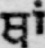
ਥਾਂ
